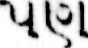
પણ
